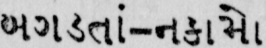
બગડતાં-નકામો
